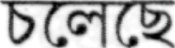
চলেছে
